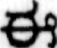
ಈ
